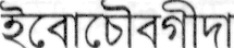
ইবোচৌবগীদা
